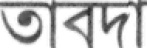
তাবদা
